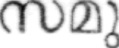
സമു
